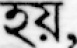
হয়,
